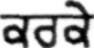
ਕਰਕੇ
